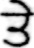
ਤੇ
